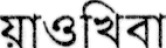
য়াওখিবা
